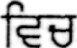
ਵਿਚ
